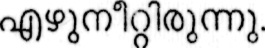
എഴുനീറ്റിരുന്നു.
